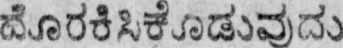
ದೊರಕಿಸಿಕೊಡುವುದು
